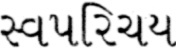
સ્વપરિચય
